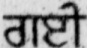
ਗਈ
